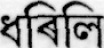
ধৰিলি
